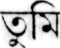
তুমি
